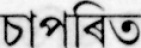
চাপৰিত
